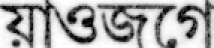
য়াওজগে
